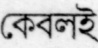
কেবলই
